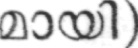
മായി)
